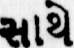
સાથે
